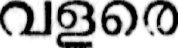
വളരെ
